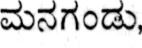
ಮನಗಂಡು,
